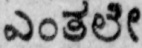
ಎಂತಲೇ
